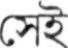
সেই
